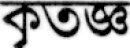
কৃতজ্ঞ
